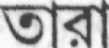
তারা
